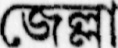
জেল্লা
